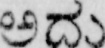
ಅದು
